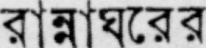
রান্নাঘরের
